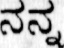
ನನ್ನ
